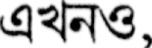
এখনও,
